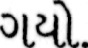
ગયો.
